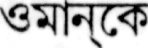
ওমান্‌কে
